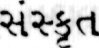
સંસ્કૃત
